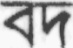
বদ
